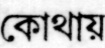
কোথায়
